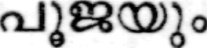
പൂജയും
